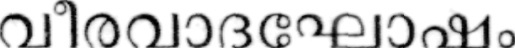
വീരവാദഘോഷം
